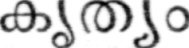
കൃത്യം
